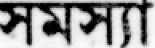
সমস্যা
